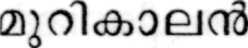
മുറികാലന്‍
